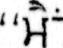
''ਮੈਂ
